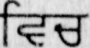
ਵਿਚ
